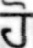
ਹੋ
